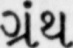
ગ્રંથ
